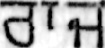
ਰਾਜ
